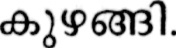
കുഴങ്ങി.
